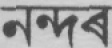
নন্দৰ
